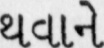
થવાને
